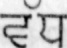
ਵੱਧ
